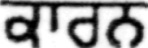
ਕਾਰਨ
